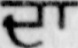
ਦਾ
